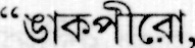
“ঙাকপীরো,
